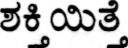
ಶಕ್ತಿಯಿತ್ತೆ
